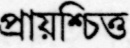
প্রায়শ্চিত্ত
